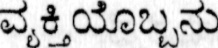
ವ್ಯಕ್ತಿಯೊಬ್ಬನು
